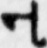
ન
